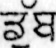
ਡੁੱਬ
